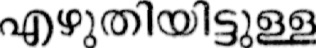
എഴുതിയിട്ടുള്ള
